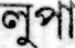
লুপা
